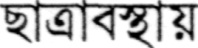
ছাত্রাবস্থায়
